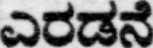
ಎರಡನೆ
